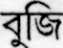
বুজি
